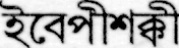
ইবেপীশক্কী
